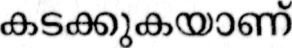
കടക്കുകയാണ്
